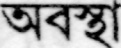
অবস্থা
